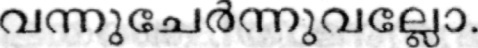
വന്നുചേര്‍ന്നുവല്ലോ.
